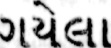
ગયેલા
